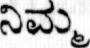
ನಿಮ್ಮ
